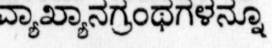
ವ್ಯಾಖ್ಯಾನಗ್ರಂಥಗಳನ್ನೂ
